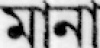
মানা
